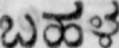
ಬಹಳ
